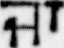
ਜਾ
